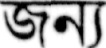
জন্য
